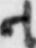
ન
